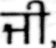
ਜੀ,
